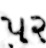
પર
